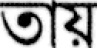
তায়
